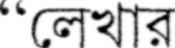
“লেখার
